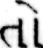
તો
